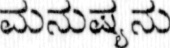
ಮನುಷ್ಯನು
